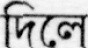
দিলে
